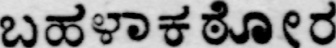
ಬಹಳಾಕಠೋರ
